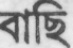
বাছি
